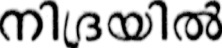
നിദ്രയില്‍
